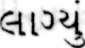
લાગ્યું
